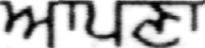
ਆਪਣਾ
